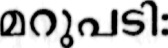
മറുപടി:
